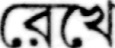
রেখে
